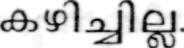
കഴിച്ചില്ല.
